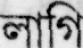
লাগি
